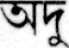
অদু
